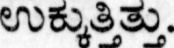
ಉಕ್ಕುತ್ತಿತ್ತು.
